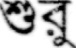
শুরু
